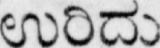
ಉರಿದು
